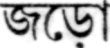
জড়ো
